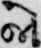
જો
